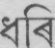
ধৰি
